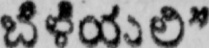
ಬೆಳೆಯಲಿ
